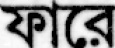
ফারে
